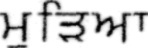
ਮੁੜਿਆ
